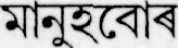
মানুহবোৰ
